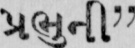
પ્રભુની”
